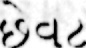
છેવટ
